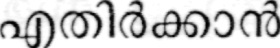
എതിര്‍ക്കാന്‍
